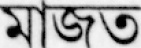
মাজত
